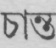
চান্ত
